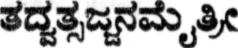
ತದ್ವತ್ಸಜ್ಜನಮೈತ್ರೀ
